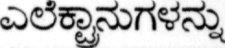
ಎಲೆಕ್ಟ್ರಾನುಗಳನ್ನು
